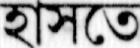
হাসতে
